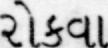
રોકવા
